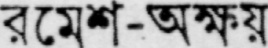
রমেশ-অক্ষয়
